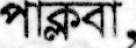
পাক্লবা,
